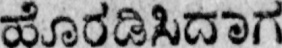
ಹೊರಡಿಸಿದಾಗ
